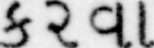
કરવા
